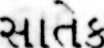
સાતેક
